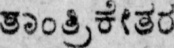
ತಾಂತ್ರಿಕೇತರ
